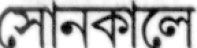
সোনকালে
